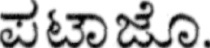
ಪಟಾಜೊ.
